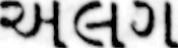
અલગ
